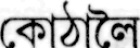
কোঠালৈ
